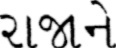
રાજાને
